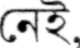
নেই,
